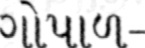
ગોપાળ-
